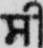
ਸੀ
